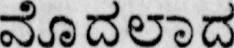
ಮೊದಲಾದ
